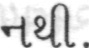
નથી.
